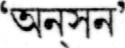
‘অন্‌সন’
